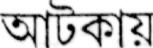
আটকায়
